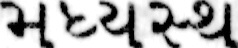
મધ્યસ્થ
